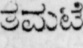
ತಮಟೆ
